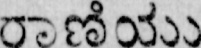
ರಾಣಿಯು
